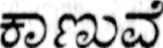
ಕಾಣುವೆ
